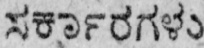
ಸರ್ಕಾರಗಳು
